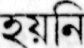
হয়নি
